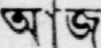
আজ
